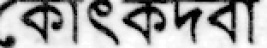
কোৎকদবা
